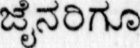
ಜೈನರಿಗೂ
